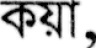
কয়া,
